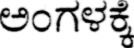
ಅಂಗಳಕ್ಕೆ
